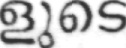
ളുടെ
